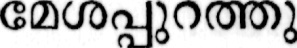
മേശപ്പുറത്തു
